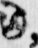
છે,
